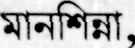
মানশিন্না,
